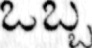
ಒಬ್ಬ
